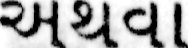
અથવા
